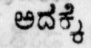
ಅದಕ್ಕೆ
